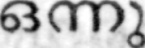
ഒന്നു
